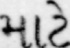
માટે
